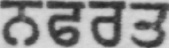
ਨਫਰਤ
